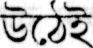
উঠেই
